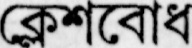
ক্লেশবোধ
